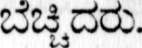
ಬೆಚ್ಚಿದರು.
